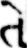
તે
